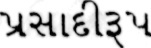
પ્રસાદીરૂપ
